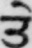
ਤੇ
